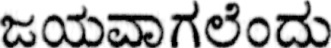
ಜಯವಾಗಲೆಂದು
